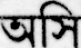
অসি
